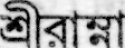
শ্রীরাম্না
